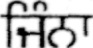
ਜਿੰਨਾ
